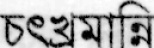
চৎখ্রমান্নি
